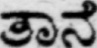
ತಾನೆ
